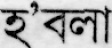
হ'বলা
